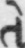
તે
